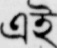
এই
